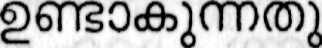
ഉണ്ടാകുന്നതു
